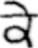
ਕੇ
